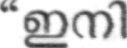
“ഇനി
